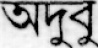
অদুবু
